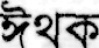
ঈথক
